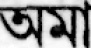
অমা
